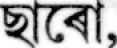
ছাৰো,
